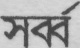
সৰ্ব্ব
